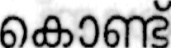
കൊണ്ട്
